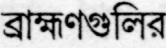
ব্রাহ্মণগুলির
